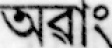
অৱাং
